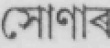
সোণাৰ
